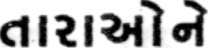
તારાઓને
